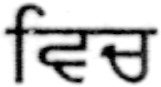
ਵਿਚ
